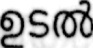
ഉടല്‍
